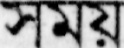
সময়
